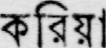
করিয়া
